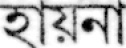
হায়না
